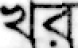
খর
